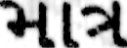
માત્ર
